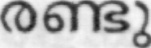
രണ്ടു
